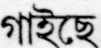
গাইছে
